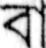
বা
